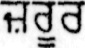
ਜ਼ਰੂਰ
